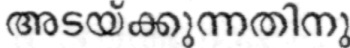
അടയ്ക്കുന്നതിനു
